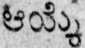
ಆಯ್ಕೆ
